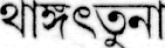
থাঙ্গৎতুনা
